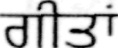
ਗੀਤਾਂ
